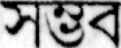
সম্ভব
